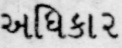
અધિકાર
